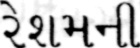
રેશમની
